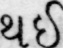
થઈ
